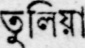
তুলিয়া
